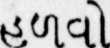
હળવો
